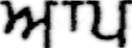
ਆਪ
